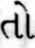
તો
